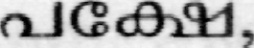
പക്ഷേ,
